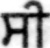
ਸੀ
